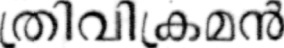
ത്രിവിക്രമന്‍
